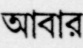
আবার
